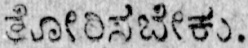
ತೋರಿಸಬೇಕು.
